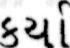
કર્યા
